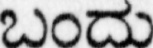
ಬಂದು
